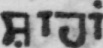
ਸ਼ਾਹਾਂ
